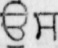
ਉਸ
